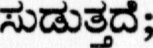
ಸುಡುತ್ತದೆ;
